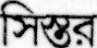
সিস্তর
